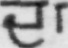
ਦਾ
